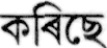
কৰিছে
